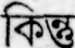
কিন্তু
